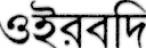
ওইরবদি
